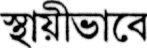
স্থায়ীভাবে
